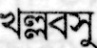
খল্লবসু
